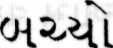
બચ્યો
